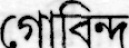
গোবিন্দ
